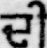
ਦੀ
